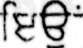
ਇਉਂ
